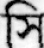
সি
